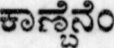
ಕಾಣ್ಬೆನೆಂ
